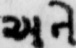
અને
